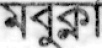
মবুক্না
